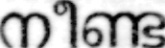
നീണ്ട
